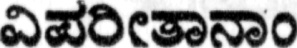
ವಿಪರೀತಾನಾಂ
